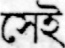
সেই
